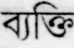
ব্যক্তি
